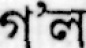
গ'ল
